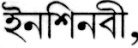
ইনশিনবী,
